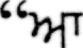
''ਆ
